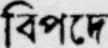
বিপদে
